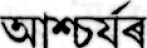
আশ্চর্যৰ
